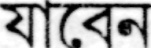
যাবেন
